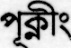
পূক্নীং
